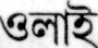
ওলাই
